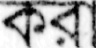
করা
